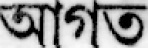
আগত
